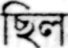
ছিল
